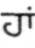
ਹਾਂ
